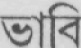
ভাবি
